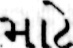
માટે
